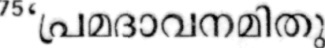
75'പ്രമദാവനമിതു
